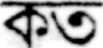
কত
